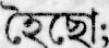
হৈছো;
